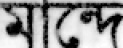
মান্দে
